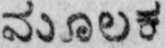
ಮೂಲಕ
